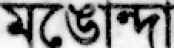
মঙোন্দা
